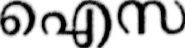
ഐസ
